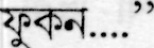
ফুকন...."
